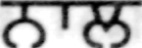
ਨਾਲ
